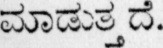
ಮಾಡುತ್ತದೆ.
